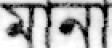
মানা
